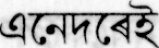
এনেদৰেই
